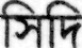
সিদি
